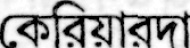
কেরিয়ারদা
